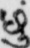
છું
